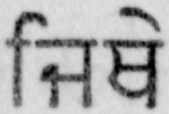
ਜਿਥੇ
